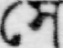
সে
